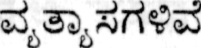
ವ್ಯತ್ಯಾಸಗಳಿವೆ
